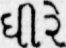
ધીરે
